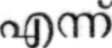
എന്ന്
